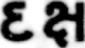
દક્ષ
